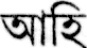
আহি
